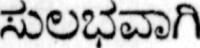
ಸುಲಭವಾಗಿ
